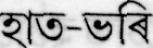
হাত-ভৰি
